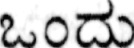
ಒಂದು
